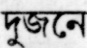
দুজনে
